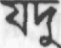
যদু
